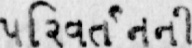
પરિવર્તનની
